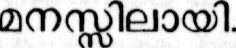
മനസ്സിലായി.
